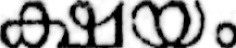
ക്ഷയം
